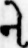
ને
